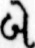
બે
